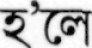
হ'লে
